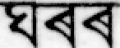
ঘৰৰ
